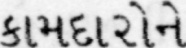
કામદારોને
